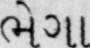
ભેગા
